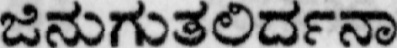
ಜಿನುಗುತಲಿರ್ದನಾ
